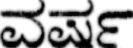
ವರ್ಷ
